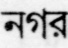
নগর
